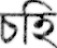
চহি
